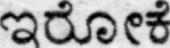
ಇರೋಕೆ
